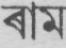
ৰাম
